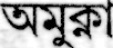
অমুক্না
